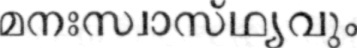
മനഃസ്വാസ്ഥ്യവും
